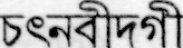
চৎনবীদগী
